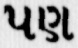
પણ
